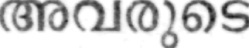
അവരുടെ
